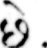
છે.
